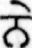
ਨੇ
